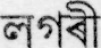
লগৰী
